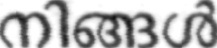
നിങ്ങള്‍
